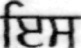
ਇਸ
